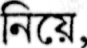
নিয়ে,
